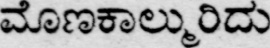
ಮೊಣಕಾಲ್ಮುರಿದು
